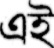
এই
